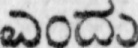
ಎಂದು
